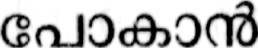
പോകാന്‍
